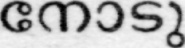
നോടു
